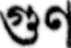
গুণ
